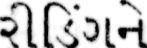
રીડિંગને
